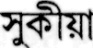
সুকীয়া
